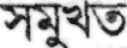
সমুখত
